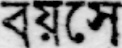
বয়সে
